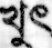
খুৎ
